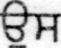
ਉਸ
